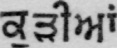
ਕੁੜੀਆਂ
